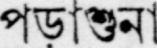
পড়াশুনা
